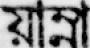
য়াম্না
